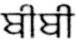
ਬੀਬੀ
